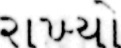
રાખ્યો
